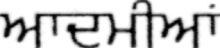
ਆਦਮੀਆਂ
